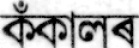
কঁকালৰ
